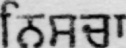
ਨਿਸਚਾ
